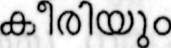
കീരിയും
